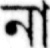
না
